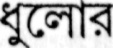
ধুলোর
